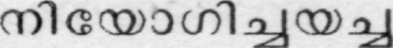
നിയോഗിച്ചയച്ച
